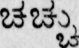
ಚಚ್ಚು
